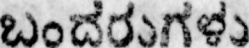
ಬಂದರುಗಳು
